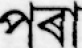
পৰা
